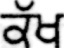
ਕੱਖ
